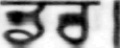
ਡਰ।
